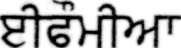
ਈਫੌਮੀਆ
